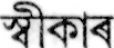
স্বীকাৰ
